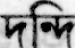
দন্দি
